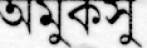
অমুকসু
